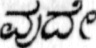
ವುದೇ
